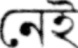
নেই
